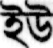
ইউ
